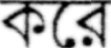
করে
